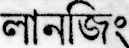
লানজিং
